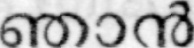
ഞാന്‍
